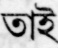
তাই
